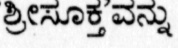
‘ಶ್ರೀಸೂಕ್ತ’ವನ್ನು
